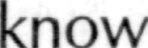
know
